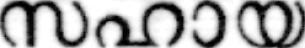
സഹായ
